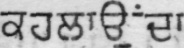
ਕਹਲਾਉਂਦਾ
